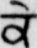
ਕੇ
